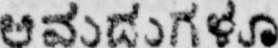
ಆಮದುಗಳೂ
